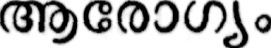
ആരോഗ്യം
